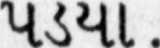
પડયા.
